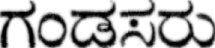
ಗಂಡಸರು
